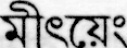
মীৎয়েং
